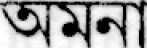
অমনা
